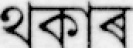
থকাৰ
